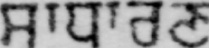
ਸਾਧਾਰਣ
